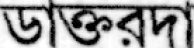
ডাক্তরদা
